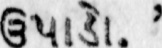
ઉપાડો.'
